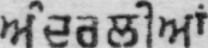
ਅੰਦਰਲੀਆਂ
